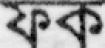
ফক
